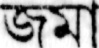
জমা
